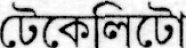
টেকেলিটো
